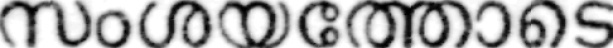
സംശയത്തോടെ
